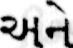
અને
